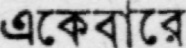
একেবারে
